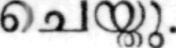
ചെയ്തു.
